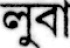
লুবা
